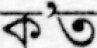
ক'ত
